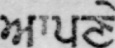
ਆਪਣੇ
